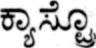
ಕ್ಯಾಸ್ಟ್ರೊ
